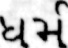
ધર્મ
